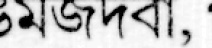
ঙমজদবা,
